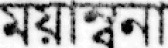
ময়াম্বনা
